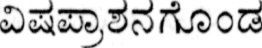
ವಿಷಪ್ರಾಶನಗೊಂಡ
